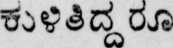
ಕುಳಿತಿದ್ದರೂ
